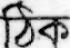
ঠিক
